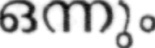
ഒന്നും
